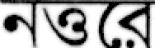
নত্তরে
